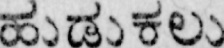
ಹುಡುಕಲು
